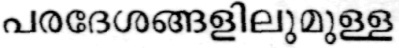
പരദേശങ്ങളിലുമുള്ള
